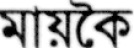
মায়কৈ
